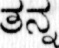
ತನ್ನ
